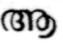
ആ
